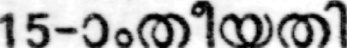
15-ാംതീയതി
